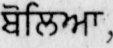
ਬੋਲਿਆ,
